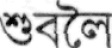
শুবলৈ
